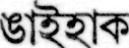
ঙাইহাক
